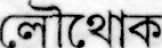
লৌথোক
